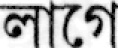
লাগে
